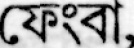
ফেংবা,
